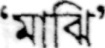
‘মাঝি’
